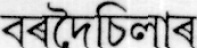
বৰদৈচিলাৰ
